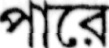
পারে
